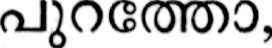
പുറത്തോ,
